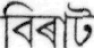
বিৰাট
